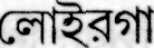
লোইরগা
